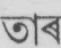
তাৰ
